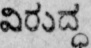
ವಿರುದ್ಧ
